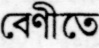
বেণীতে
